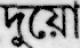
দুয়ো
